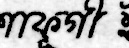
শাফূগী
